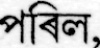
পৰিল,
